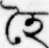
হৈ
